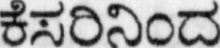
ಕೆಸರಿನಿಂದ
